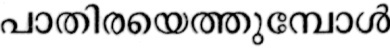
പാതിരയെത്തുമ്പോള്‍
